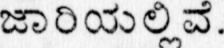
ಜಾರಿಯಲ್ಲಿವೆ.
